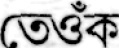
তেওঁক
